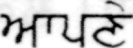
ਆਪਣੇ
